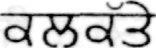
ਕਲਕੱਤੇ
